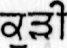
ਕੁੜੀ
